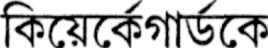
কিয়ের্কেগার্ডকে
